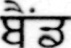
ਬੈਂਡ
